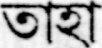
তাহা
